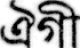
ঐগী
